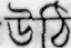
উঠি
